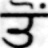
ਤੋਂ
